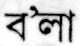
ব'লা
